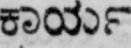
ಕಾರ್ಯ
